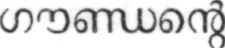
ഗൗണ്ഡന്റെ
